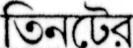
তিনটের
